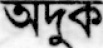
অদুক
